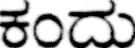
ಕಂದು
